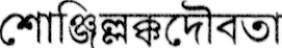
শোঞ্জিল্লক্কদৌবতা
